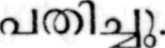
പതിച്ചു.
